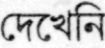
দেখেনি
